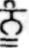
ਨੂੰ
